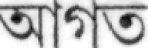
আগত
